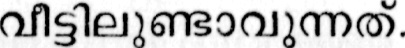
വീട്ടിലുണ്ടാവുന്നത്.
